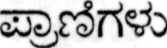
ಪ್ರಾಣಿಗಳು
